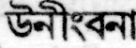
উনীংবনা
